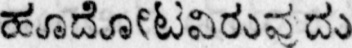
ಹೂದೋಟವಿರುವುದು
